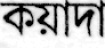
কয়াদা
